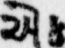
એક
